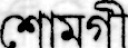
শোমগী
